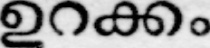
ഉറക്കം
